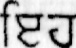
ਇਹ
